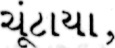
ચૂંટાયા,
